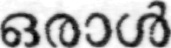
ഒരാള്‍
